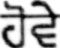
ਹੋਵੇ
